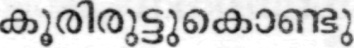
കൂരിരുട്ടുകൊണ്ടു
